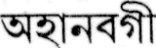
অহানবগী
